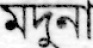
মদুনা
